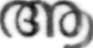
ആ
